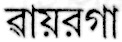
ৱায়রগা
